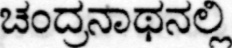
ಚಂದ್ರನಾಥನಲ್ಲಿ
